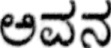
ಅವನ
